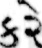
કરે
